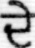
ਦੇ
